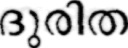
ദുരിത
